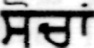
ਸੋਚਾਂ
